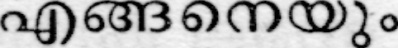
എങ്ങനെയും
